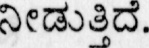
ನೀಡುತ್ತಿದೆ.
